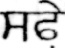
ਸਫ਼ੇ
